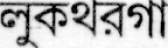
লুকথরগা
